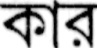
কার
